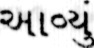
આવ્યું
